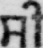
ਸੀ
